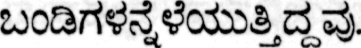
ಬಂಡಿಗಳನ್ನೆಳೆಯುತ್ತಿದ್ದವು.
